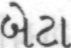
બેટા
